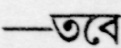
–তবে
